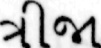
ત્રીજા
